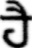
ਹੈ
